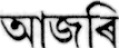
আজৰি
